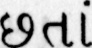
છતાં
